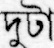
দুটা
